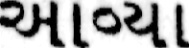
આવ્યા
